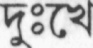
দুঃখে
